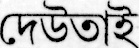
দেউতাই
